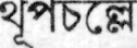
থূপচল্লে
